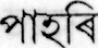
পাহৰি
